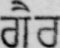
ਗੈਰ
